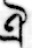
ঐ
